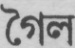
গৈল
